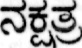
ನಕ್ಷತ್ರ
